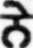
ਨੇ
